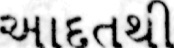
આદતથી
